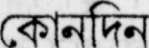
কোনদিন
